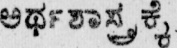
ಅರ್ಥಶಾಸ್ತ್ರಕ್ಕೆ.
